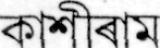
কাশীৰাম
